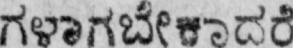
ಗಳಾಗಬೇಕಾದರೆ
